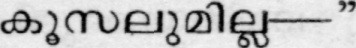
കൂസലുമില്ല-"
